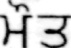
ਮੌਤ
